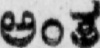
ಅಂತ
